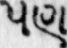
પણ
